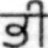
ਭੀ
